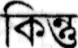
কিন্তু
